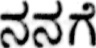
ನನಗೆ
